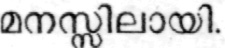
മനസ്സിലായി.
